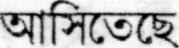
আসিতেছে
